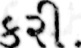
કરી.
